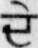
ਦੇ
